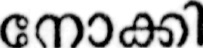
നോക്കി
